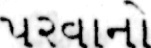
પરવાનો
